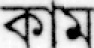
কাম
